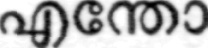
എന്തോ
